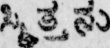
ಸ್ಮಿತ್ತನು
